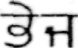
ਭੇਜ
